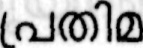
പ്രതിമ
